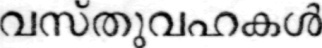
വസ്തുവഹകള്‍
